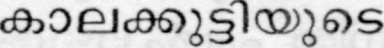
കാലക്കുട്ടിയുടെ
